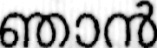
ഞാന്‍
